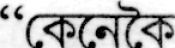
"কেনেকৈ
